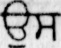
ਉਸ
